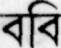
ববি
